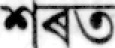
শৰত
